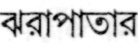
ঝরাপাতার
